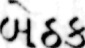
બેઠક
